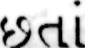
છતાં
